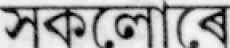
সকলোৰে
